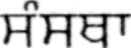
ਸੰਸਥਾ
